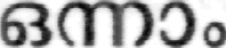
ഒന്നാം
